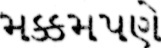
મક્કમપણે
